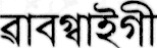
ৱাবগ্বাইগী
